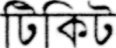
টিকিট
